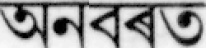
অনবৰত
